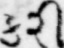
કરી
